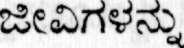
ಜೀವಿಗಳನ್ನು
